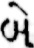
બે
